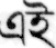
এই
